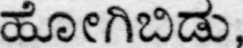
ಹೋಗಿಬಿಡು,
